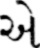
એ
